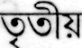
তৃতীয়
